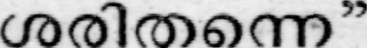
ശരിതന്നെ”
